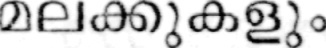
മലക്കുകളും
